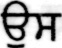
ਉਸ
